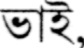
ভাই,
